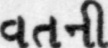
વતની
